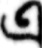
এ
